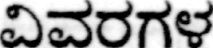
ವಿವರಗಳ
